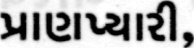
પ્રાણપ્યારી,
